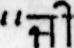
''ਜੀ
